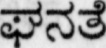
ಘನತೆ
